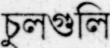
চুলগুলি
